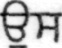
ਉਸ
